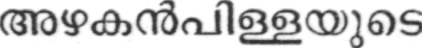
അഴകന്‍പിള്ളയുടെ
